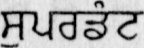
ਸੁਪਰਡੰਟ
